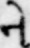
ને
